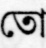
তো
